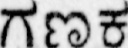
ಗಣಕ
